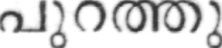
പുറത്തു
